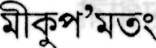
মীকুপ’মতং
